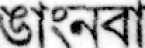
ঙাংনবা
